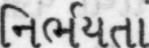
નિર્ભયતા
